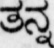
ತನ್ನ
